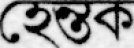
হেন্তক
